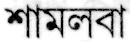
শামলবা
